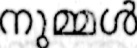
നുമ്മള്‍
